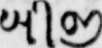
બીજી
